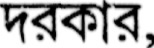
দরকার,
